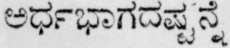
ಅರ್ಧಭಾಗದಷ್ಟನ್ನೆ
